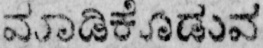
ಮಾಡಿಕೊಡುವ
